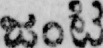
ಜಂಟಿ
